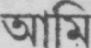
আমি
